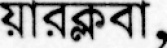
য়ারক্লবা,
